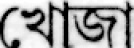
খোজা
